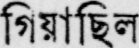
গিয়াছিল
